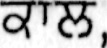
ਕਾਲ,
